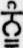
ਨੂੰ
